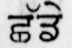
ਛੱਡੇ
